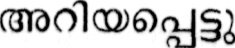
അറിയപ്പെട്ടു
